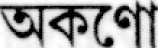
অকণো
